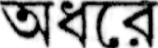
অধরে
